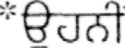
*ਉਹਨੀ
